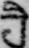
ਹੈ
